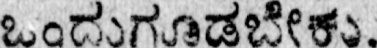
ಒಂದುಗೂಡಬೇಕು.
